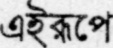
এইরূপে
